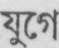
যুগে
